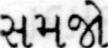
સમજો
